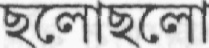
ছলোছলো
